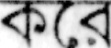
করে
